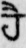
ਹੈ
